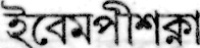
ইবেমপীশক্না
